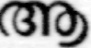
ആ
